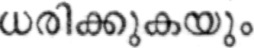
ധരിക്കുകയും
